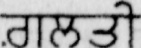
ਗ਼ਲਤੀ
